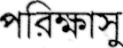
পরিক্ষাসু
